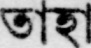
তাহা
